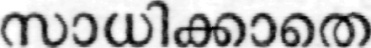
സാധിക്കാതെ
